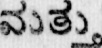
ಮತ್ತು
